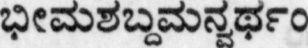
ಭೀಮಶಬ್ದಮನ್ವರ್ಥಂ
